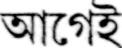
আগেই
